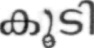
കൂടി
